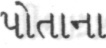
પોતાના
